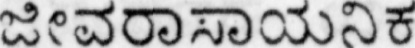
ಜೀವರಾಸಾಯನಿಕ
